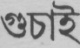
গুচাই
